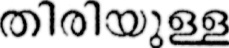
തിരിയുള്ള
